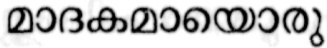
മാദകമായൊരു
